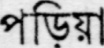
পড়িয়া
